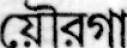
য়ৌরগা
